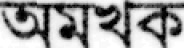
অমখক
